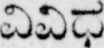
ವಿವಿಧ
